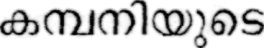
കമ്പനിയുടെ
